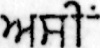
ਅਸੀਂ
